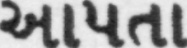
આપતા
